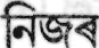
নিজৰ
